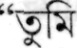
"তুমি
